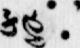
કહું.'
